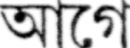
আগে
